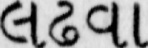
લઢવા
